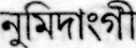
নুমিদাংগী
